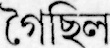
গৈছিল
